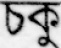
চকু
